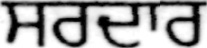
ਸਰਦਾਰ
